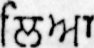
ਲਿਆ
